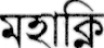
মহাক্নি
